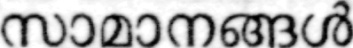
സാമാനങ്ങള്‍
